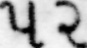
પર
